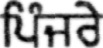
ਪਿੰਜਰੇ
